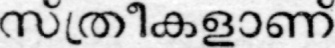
സ്ത്രീകളാണ്
